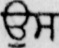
ਉਸ
